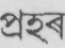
প্ৰহৰ
